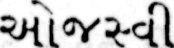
ઓજસ્વી
